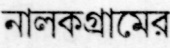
নালকগ্রামের
